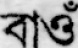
বাওঁ
